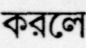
করলে
